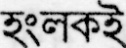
হংলকই
